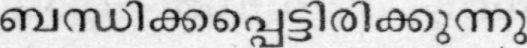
ബന്ധിക്കപ്പെട്ടിരിക്കുന്നു
